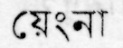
য়েংনা
